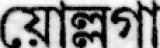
য়োল্লগা
